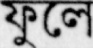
ফুলে
